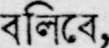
বলিবে,
